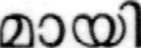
മായി
